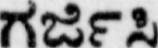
ಗರ್ಜಿಸಿ
